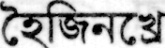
হৈজিনখ্রে
